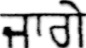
ਜਾਗੇ
